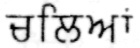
ਚਲਿਆਂ
